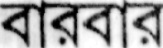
বারবার
